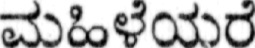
ಮಹಿಳೆಯರೆ
